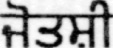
ਜੋਤਸ਼ੀ
